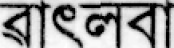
ৱাৎলবা
